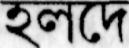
হলদে
